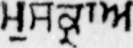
ਮੁਸਕ੍ਰਾਅ
